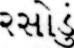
રસોડું
